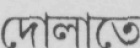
দোলাতে
